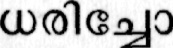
ധരിച്ചോ
